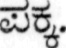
ಪಕ್ಕ.
